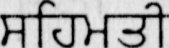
ਸਹਿਮਤੀ
